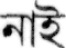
নাই
